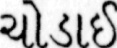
ચોડાઈ
